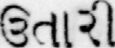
ઉતારી
